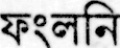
ফংলনি
